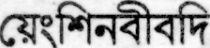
য়েংশিনবীবদি
